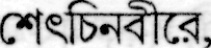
শেৎচিনবীরে,
